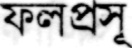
ফলপ্রসূ
